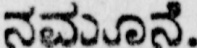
ನಮೂನೆ.
